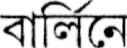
বার্লিনে
